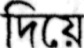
দিয়ে
